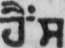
ਹੈਂਸ
